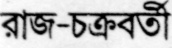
রাজ-চক্রবর্তী
